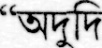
“অদুদি
